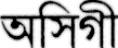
অসিগী
